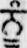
ਨੂੰ
